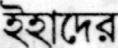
ইহাদের
